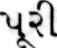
પૂરી
